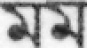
মম
